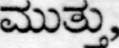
ಮುತ್ತು,
